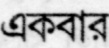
একবার
